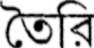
তৈরি
